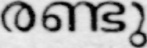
രണ്ടു
